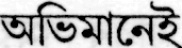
অভিমানেই
